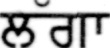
ਲੱਗਾ
